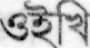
ওইখি
